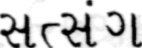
સત્સંગ
